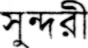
সুন্দরী
